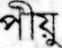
পীয়ু
